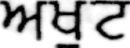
ਅਖੁਟ
